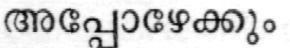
അപ്പോഴേക്കും
